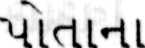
પોતાના
